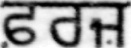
ਫ਼ਰਜ਼
